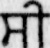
ਸੀ
